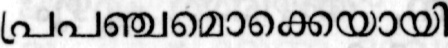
പ്രപഞ്ചമൊക്കെയായി
